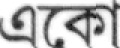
একো
